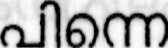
പിന്നെ
